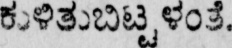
ಕುಳಿತುಬಿಟ್ಟಳಂತೆ.
